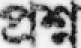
প্ৰশ্ন
